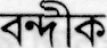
বন্দীক
